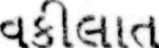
વકીલાત
